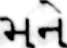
મને
